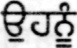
ਉਹਨੂੰ
